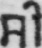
ਸੀ
